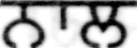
ਨਾਲ
